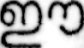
ഈ
